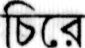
চিরে
